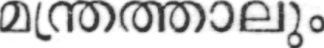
മന്ത്രത്താലും
